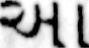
આ
